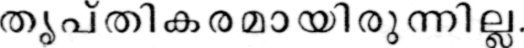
തൃപ്തികരമായിരുന്നില്ല.
